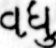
વધુ
